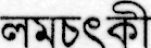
লমচৎকী
